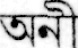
অনী
